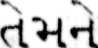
તેમને
